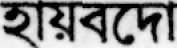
হায়বদো
